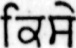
ਕਿਸੇ
